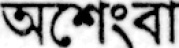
অশেংবা
